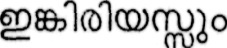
ഇങ്കിരിയസ്സും
